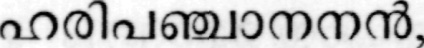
ഹരിപഞ്ചാനനന്‍,
